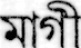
মাগী
